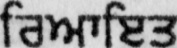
ਰਿਆਇਤ
